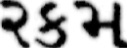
રકમ
